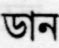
ডান
